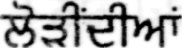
ਲੋੜੀਂਦੀਆਂ
